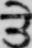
ਤੇ
